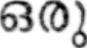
ഒരു
